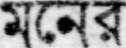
মনের
